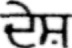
ਦੇਸ਼
